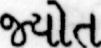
જ્યોત
